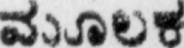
ಮೂಲಕ
